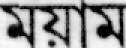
ময়াম
